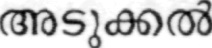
അടുക്കല്‍
